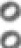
ঃ
